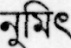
নুমিৎ
